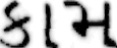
કામ
